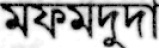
মফমদুদা
